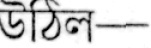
উঠিল-
